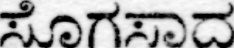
ಸೊಗಸಾದ
